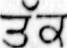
ਤੱਕ
